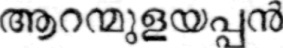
ആറന്മുളയപ്പന്‍
